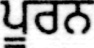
ਪੂਰਨ
